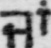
ਜਾਂ
